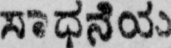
ಸಾಧನೆಯ
